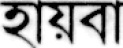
হায়বা
